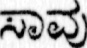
ಸಾವು
